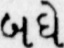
બધે
